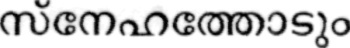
സ്നേഹത്തോടും
